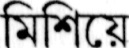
মিশিয়ে
